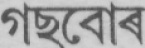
গছবোৰ
